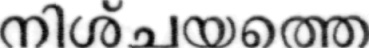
നിശ്ചയത്തെ
